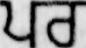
ਪਰ
